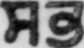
ਸਭ
